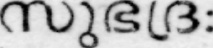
സുഭദ്ര:
